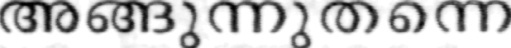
അങ്ങുന്നുതന്നെ
